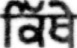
ਕਿੱਥੇ
